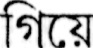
গিয়ে
